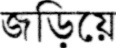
জড়িয়ে
